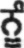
ਨੂੰ
